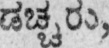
ಡಚ್ಚರು,
